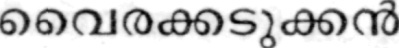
വൈരക്കടുക്കന്‍
